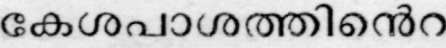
കേശപാശത്തിന്റെ
